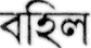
বহিল
